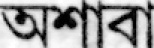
অশাবা
